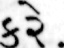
કરે.
